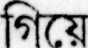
গিয়ে
